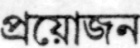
প্রয়োজন
